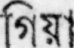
গিয়া
